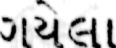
ગયેલા
